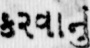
કરવાનું
